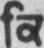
ਕਿ
